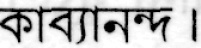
কাব্যানন্দ।
